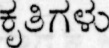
ಕೃತಿಗಳು
